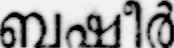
ബഷീര്‍
